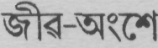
জীৱ-অংশে
